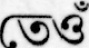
তেওঁ
